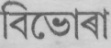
বিভোৰা
